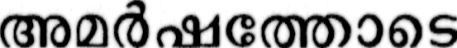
അമര്‍ഷത്തോടെ
